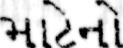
માટેનો
